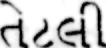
તેટલી
